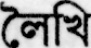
লৈখি
